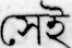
সেই
